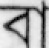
বা
